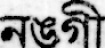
নঙগী
